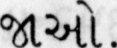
જાઓ.
